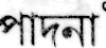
পাদনা
